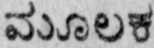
ಮೂಲಕ
